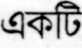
একটি
